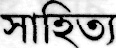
সাহিত্য
